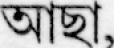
আছা,
